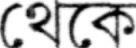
থেকে
